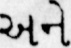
અને
